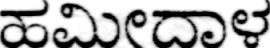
ಹಮೀದಾಳ
